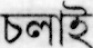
চলাই
